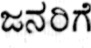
ಜನರಿಗೆ
